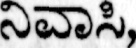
ನಿವಾಸಿ,
